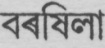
বৰষিলা
